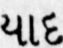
યાદ
